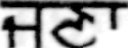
ਜਣਾ
